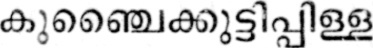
കുഞ്ചൈക്കുട്ടിപ്പിള്ള
